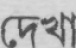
দেখা
